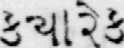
ક્યારેક
